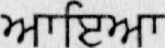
ਆਇਆ
